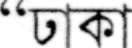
“ঢাকা
